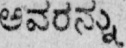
ಅವರನ್ನು
